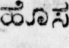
ಹೊಸ
